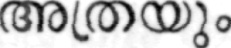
അത്രയും
